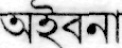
অইবনা
